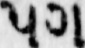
પગ
